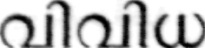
വിവിധ
